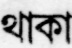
থাকা
